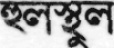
হুলস্থুল
